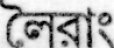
লৈরাং
